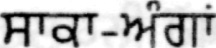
ਸਾਕਾ-ਅੰਗਾਂ
